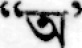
"অ'
